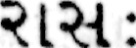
રાસઃ
